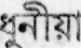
ধুনীয়া
